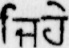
ਜਿਹੇ
